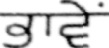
ਭਾਵੇਂ
